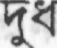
দুধ
